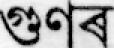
গুণৰ
